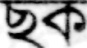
ছক
